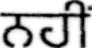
ਨਹੀਂ
